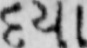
દયા
